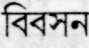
বিবসন
